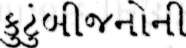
કુટુંબીજનોની
